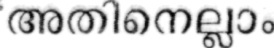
'അതിനെല്ലാം
